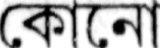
কোনো
